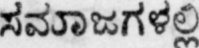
ಸಮಾಜಗಳಲ್ಲಿ
